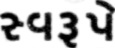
સ્વરૂપે
